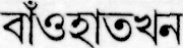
বাঁওহাতখন
